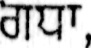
ਗਧਾ,
